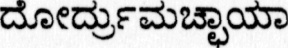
ದೋರ್ದ್ರುಮಚ್ಛಾಯಾ
